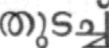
തുടച്ച്
